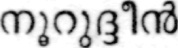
നൂറുദ്ദീന്‍
